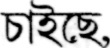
চাইছে,
